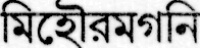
মিহৌরমগনি
